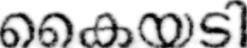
കൈയടി
